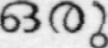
ഒരു
